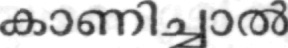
കാണിച്ചാല്‍
